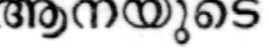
ആനയുടെ
